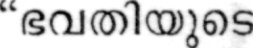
“ഭവതിയുടെ
